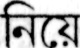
নিয়ে
